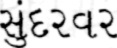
સુંદરવર
